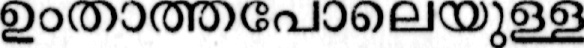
ഉംതാത്തപോലെയുള്ള
